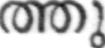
ത്തു
